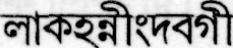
লাকহন্নীংদবগী
